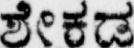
ಶೇಕಡ
